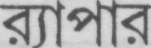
র‌্যাপার
